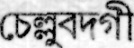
চেল্লুবদগী
